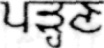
ਪੜ੍ਹਣ
